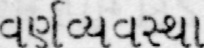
વર્ણવ્યવસ્થા
